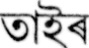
তাইৰ
